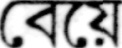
বেয়ে
